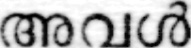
അവള്‍
